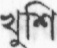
খুশি
